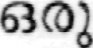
ഒരു
